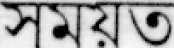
সময়ত
